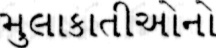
મુલાકાતીઓનો
